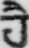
ਹੈ
